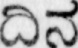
ದಿನ
